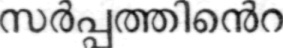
സര്‍പ്പത്തിന്റെ
